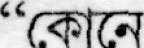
"কোনে
